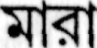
মারা
